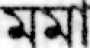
মমা
